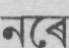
নৰে
